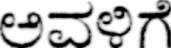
ಅವಳಿಗೆ
